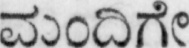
ಮಂದಿಗೇ
